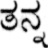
ತನ್ನ
